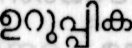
ഉറുപ്പിക
